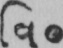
વિ.
